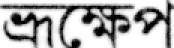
ভ্রূক্ষেপ
